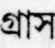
গ্রাস
